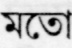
মতো
